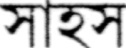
সাহস
